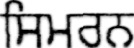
ਸਿਮਰਨ
